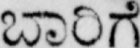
ಬಾರಿಗೆ
